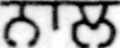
ਨਾਲ
